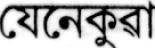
যেনেকুৱা
